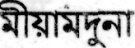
মীয়ামদুনা
